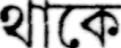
থাকে
